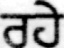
ਰਹੇ
